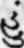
હું
